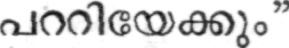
പററിയേക്കും”
